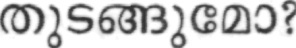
തുടങ്ങുമോ?
